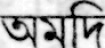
অমদি
